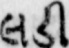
લડી
